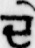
ਦੇ
